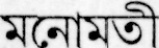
মনোমতী
